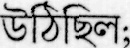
উঠিছিল;
